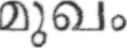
മുഖം
